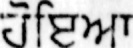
ਹੋਇਆ
